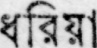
ধরিয়া
